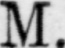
M
